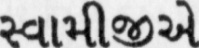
સ્વામીજીએ
